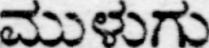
ಮುಳುಗು
